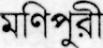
মণিপুরী
